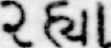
રહ્યા
